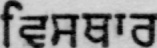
ਵਿਸਥਾਰ
